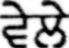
ਵੇਲੇ
